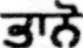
ਭਾਨੋ
